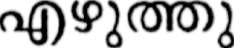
എഴുത്തു
